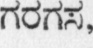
ಗರಗಸ,
